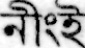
নীংই
